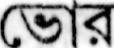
ভোর
